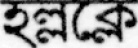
হল্লক্লে
